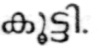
കൂട്ടി.
